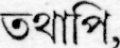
তথাপি,
